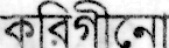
করিগীনো
